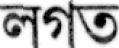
লগত
